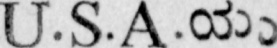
U.S.A.ಯು
